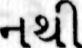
નથી
